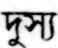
দুস্য
